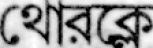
থোরক্লে
